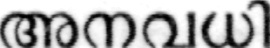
അനവധി
